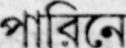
পারিনে
